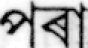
পৰা
